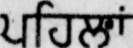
ਪਹਿਲਾਂ
